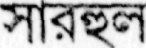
সারহুল
